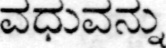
ವಧುವನ್ನು
